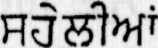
ਸਹੇਲੀਆਂ
